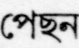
পেছন
